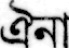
ঐনা
